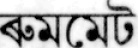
ৰুমমেট
